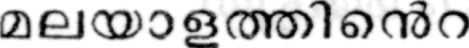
മലയാളത്തിന്റെ
